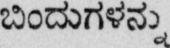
ಬಿಂದುಗಳನ್ನು
